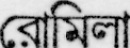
রোমিলা
